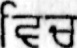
ਵਿਚ
